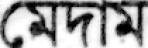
মেদাম
